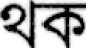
থক
